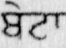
ਬੇਟਾ
